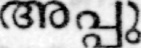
അപ്പു
